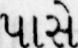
પાસે
